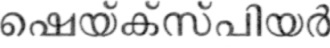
ഷെയ്ക്സ്പിയര്‍
